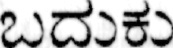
ಬದುಕು
